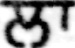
ਲਾ
